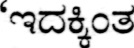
'ಇದಕ್ಕಿಂತ
